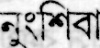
নুংশিবা
